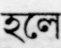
হলে
